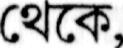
থেকে,
